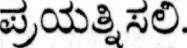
ಪ್ರಯತ್ನಿಸಲಿ.
